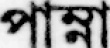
পাম্না
